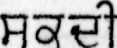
ਸਕਦੀ
